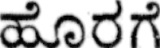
ಹೊರಗೆ
